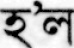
হ'ল
